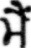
ਮੈਂ
